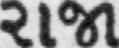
રાજા
